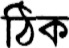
ঠিক
